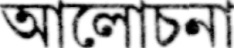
আলোচনা
